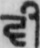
ਵੀ
